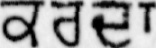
ਕਰਦਾ
